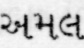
અમલ
